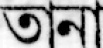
তানা
